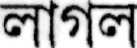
লাগল
